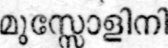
മുസ്സോളിനി
